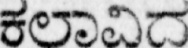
ಕಲಾವಿದ
